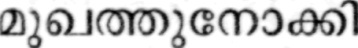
മുഖത്തുനോക്കി
